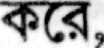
করে,
